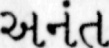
અનંત
